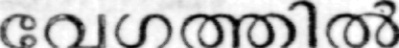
വേഗത്തില്‍
